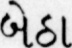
બેઠા
